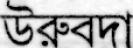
উরুবদা
